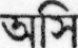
অসি
